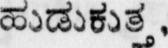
ಹುಡುಕುತ್ತ,
